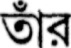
তাঁর
